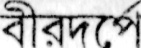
বীরদর্পে
